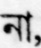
না,
